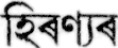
হিৰণ্যৰ
